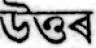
উত্তৰ
